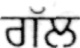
ਗੱਲ
